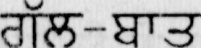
ਗੱਲ-ਬਾਤ
